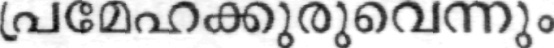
പ്രമേഹക്കുരുവെന്നും
